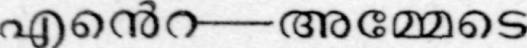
എന്റെ-അമ്മേടെ
